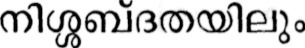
നിശ്ശബ്ദതയിലും
